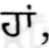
ਹਾਂ,
